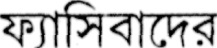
ফ্যাসিবাদের
